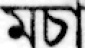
মচা
